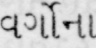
વર્ગોના
